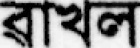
ৱাখল
